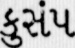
કુસંપ
